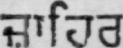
ਜ਼ਾਹਿਰ
